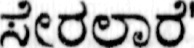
ಸೇರಲಾರೆ’
